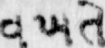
વખતે
